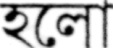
হলো
